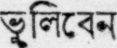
ভুলিবেন
